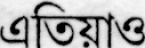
এতিয়াও
